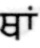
ਥਾਂ
